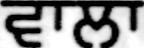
ਵਾਲਾ
